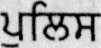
ਪੁਲਿਸ
